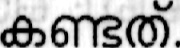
കണ്ടത്.
